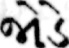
જોડે
